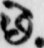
છે.
